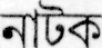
নাটক
